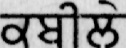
ਕਬੀਲੇ
